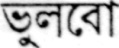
ভুলবো
